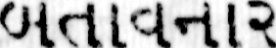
બતાવનાર
